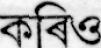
কৰিও
